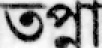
তপ্ন
